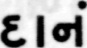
દાનં
